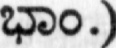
ಭಾಂ.)
